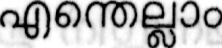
എന്തെല്ലാം
